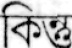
কিন্তু
